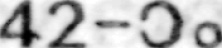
42-ാം
